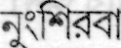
নুংশিরবা
